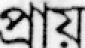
প্ৰায়
